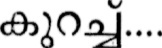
കുറച്ച്....
